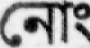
নোং
